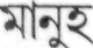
মানুহ
